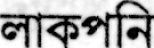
লাকপনি
